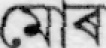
মোৰ
